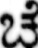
ಚೆ
